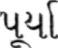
પૂર્યા
